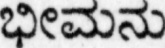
ಭೀಮನು
